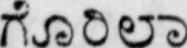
ಗೊರಿಲಾ
